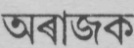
অৰাজক
